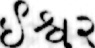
ઈશ્વર
